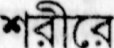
শরীরে
